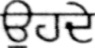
ਉਹਦੇ
